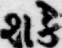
શકે
